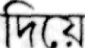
দিয়ে
